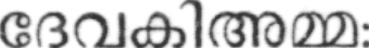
ദേവകിഅമ്മ:
